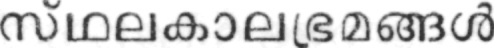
സ്ഥലകാലഭ്രമങ്ങള്‍
